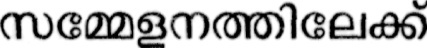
സമ്മേളനത്തിലേക്ക്
